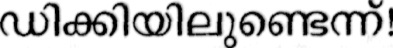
ഡിക്കിയിലുണ്ടെന്ന്!
